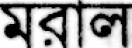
মরাল
